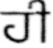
ਹੀ
